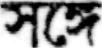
সঙ্গে
